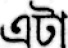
এটা
